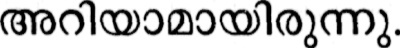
അറിയാമായിരുന്നു.
